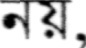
নয়,
